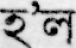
হ'ল
